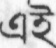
এই
